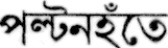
পল্টনহঁতে
